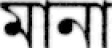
মানা
